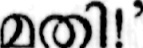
മതി!'
